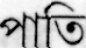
পাতি
